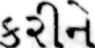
કરીને
